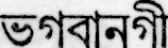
ভগবানগী
